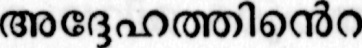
അദ്ദേഹത്തിന്റെ
